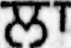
ਲਾ
